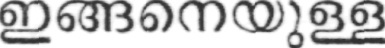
ഇങ്ങനെയുള്ള
